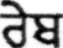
ਰੇਬ
